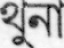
থুনা
